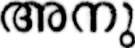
അനു
